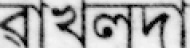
ৱাখলদা
